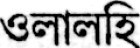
ওলালহি
